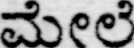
ಮೇಲೆ
